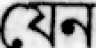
যেন
